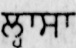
ਲ੍ਹਾਸਾ
